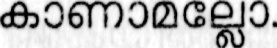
കാണാമല്ലോ.
